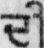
ਦੀ
